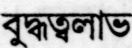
বুদ্ধত্বলাভ
